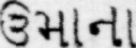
ઉમાના
